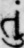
તું
